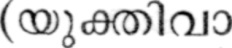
(യുക്തിവാ
